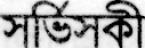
সর্ভিসগী
